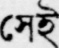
সেই
